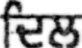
ਦਿਲ
